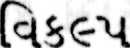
વિકલ્પ
